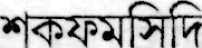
শকফমসিদি
